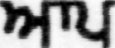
ਆਪ
